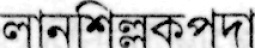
লানশিল্লকপদা
